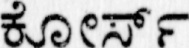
ಕೋರ್ಸ್
